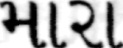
મારા
